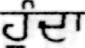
ਹੁੰਦਾ
